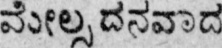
ಮೇಲ್ಸದನವಾದ
